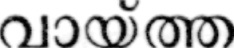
വായ്ത്ത
